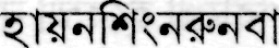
হায়নশিংনরুনবা
